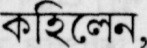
কহিলেন,
